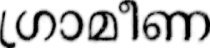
ഗ്രാമീണ
